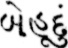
બેહૂદું
